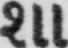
શા
